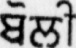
ਬੋਲੀ
